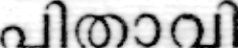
പിതാവി
